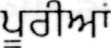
ਪੂਰੀਆਂ
